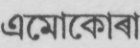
এমোকোৰা
